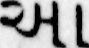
આ
